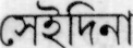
সেইদিনা
